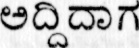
ಅದ್ದಿದಾಗ
